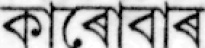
কাৰোবাৰ
